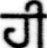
ਹੀ
